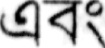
এবং
